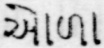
ઓળા
